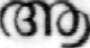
ആ
